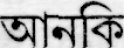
আনকি
